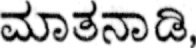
ಮಾತನಾಡಿ,
